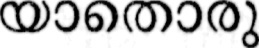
യാതൊരു
